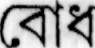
বোধ
